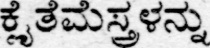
ಕ್ಲೈತೆಮೆಸ್ತ್ರಳನ್ನು
